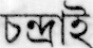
চন্দ্রাই
